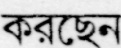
করছেন
